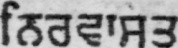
ਨਿਰਵਾਸਤ
